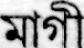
মাগী
